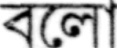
বলো
